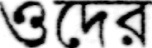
ওদের
